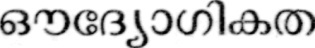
ഔദ്യോഗികത
